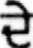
ਦੇ
